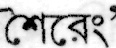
শৈরেং’
